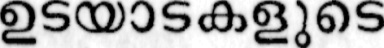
ഉടയാടകളുടെ
